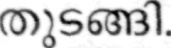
തുടങ്ങി.
